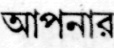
আপনার
